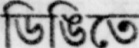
ডিঙিতে
